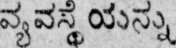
ವ್ಯವಸ್ಥೆಯನ್ನು
